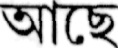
আছে
